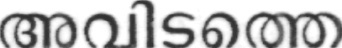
അവിടത്തെ
